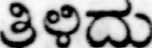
ತಿಳಿದು
